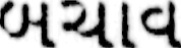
બચાવ
